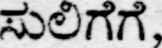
ಸುಲಿಗೆಗೆ,
